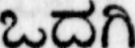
ಒದಗಿ
